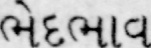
ભેદભાવ
